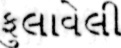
ફુલાવેલી
